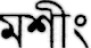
মশীং
